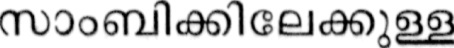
സാംബിക്കിലേക്കുള്ള
